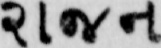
રાજન
